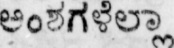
ಅಂಶಗಳೆಲ್ಲಾ
